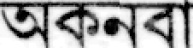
অকনবা
